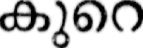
കുറെ
